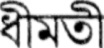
ধীমতী
